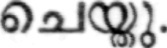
ചെയ്തു.
